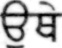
ਉਥੇ
